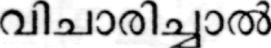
വിചാരിച്ചാല്‍
